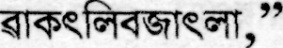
ৱাকৎলিবজাৎলা,”
